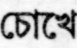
চোখে
